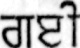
ਗਈ
